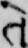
તે
